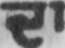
ਦਾ
